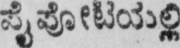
ಪೈಪೋಟಿಯಲ್ಲಿ
